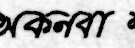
অকনবা
